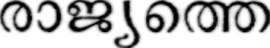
രാജ്യത്തെ
